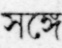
সঙ্গে
